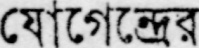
যোগেন্দ্রের
